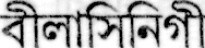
বীলাসিনগী
